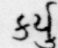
કર્યુ
